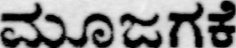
ಮೂಜಗಕೆ
